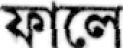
ফালে
